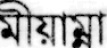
মীয়াম্না
